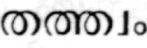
തത്ത്വം.
